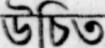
উচিত
